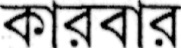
কারবার
